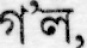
গ'ল,
